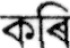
কৰি
